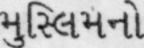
મુસ્લિમનો
